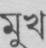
মুখ
